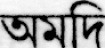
অমদি
